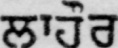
ਲਾਹੌਰ
